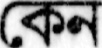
কেন
